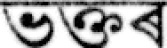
ভক্তৰ
